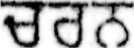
ਚਰਨ
